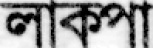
লাকপা
